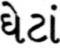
ઘેટાં
